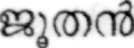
ജൂതന്‍
